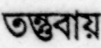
তন্তুবায়
